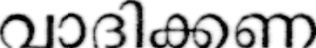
വാദിക്കണ
